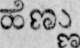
ಹೆಣ್ಣು
